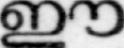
ഈ
